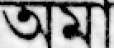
অমা
